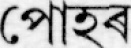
পোহৰ
